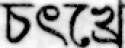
চৎখ্রে
